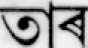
তাৰ
